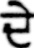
ਦੇ
